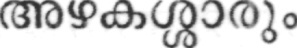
അഴകശ്ശാരും
